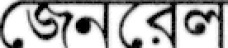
জেনরেল
